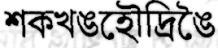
শকখঙহৌদ্রিঙৈ
